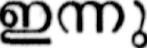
ഇന്നു
